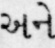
અને
